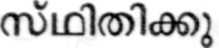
സ്ഥിതിക്കു
